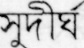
সুদীর্ঘ
